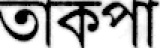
তাকপা
